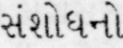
સંશોધનો
